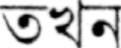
তখন
